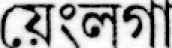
য়েংলগা
